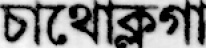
চাথোক্লগা
